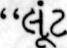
"લૂંટ
